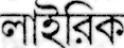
লাইরিক
